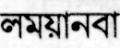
লময়ানবা
